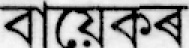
বায়েকৰ
